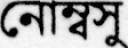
নোম্বসু
